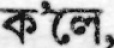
ক'লে,
